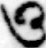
ও
